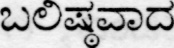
ಬಲಿಷ್ಠವಾದ
